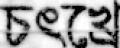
চৎখ্রে
